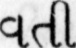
વતી
